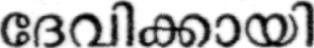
ദേവിക്കായി
